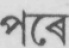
পৰে
